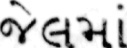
જેલમાં
